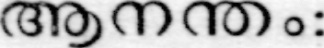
ആനന്തം:
